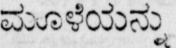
ಮೂಳೆಯನ್ನು
